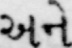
અને
